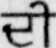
ਦੀ
